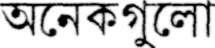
অনেকগুলো
